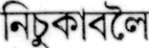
নিচুকাবলৈ
